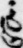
હું
